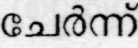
ചേര്‍ന്ന്
